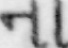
ના
